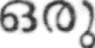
ഒരു
